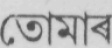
তোমাৰ
